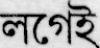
লগেই
